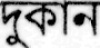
দুকান
